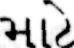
માટે
